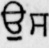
ਉਸ
